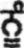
ਨੂੰ
